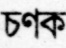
চণক
